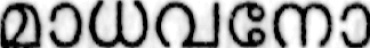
മാധവനോ
